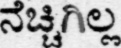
ನೆಚ್ಚಿಗಿಲ್ಲ
